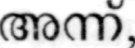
അന്ന്,
